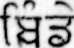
ਬਿੰਡੇ
